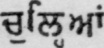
ਚੁਲ੍ਹਿਆਂ
